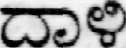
ದಾಳಿ
